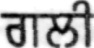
ਗਲੀ
